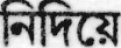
নিদিয়ে
